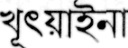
খূৎয়াইনা
